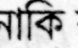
নাকি
